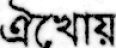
ঐখোয়
